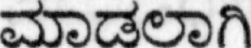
ಮಾಡಲಾಗಿ
